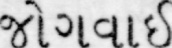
જોગવાઈ
